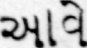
આવે
